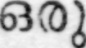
ഒരു
